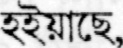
হইয়াছে,
